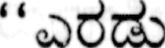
"ಎರಡು
